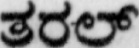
ತರಲ್
